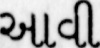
આવી
